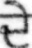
ਦੇ
